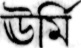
ঊর্মি
